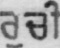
ਰੁਚੀ
